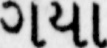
ગયા
